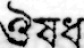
ঔষধ
